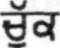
ਚੁੱਕ
